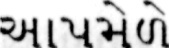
આપમેળે
